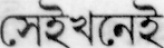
সেইখনেই
